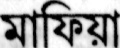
মাফিয়া
